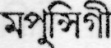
মপুন্সিগী
